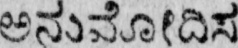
ಅನುಮೋದಿಸ
